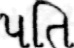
પતિ
